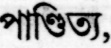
পাণ্ডিত্য,
